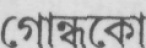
গোন্ধকো
